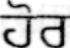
ਹੋਰ
